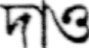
দাও
